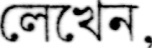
লেখেন,
